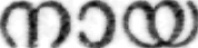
നായ
